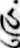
હું
